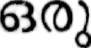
ഒരു
